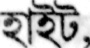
হাইট,
